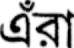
এঁরা
